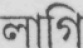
লাগি
